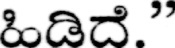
ಹಿಡಿದೆ."
